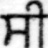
ਸੀ
